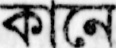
কানে
